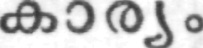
കാര്യം
